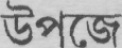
উপজে
